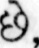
છે,
